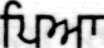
ਪਿਆ
